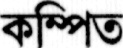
কম্পিত
